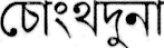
চোংথদুনা
